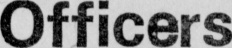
Officers
